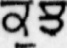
ਕੁਝ
